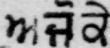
ਅਜੋਕੇ
